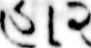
હાર
